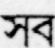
সব
